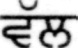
ਵੱਲ
